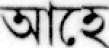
আহে
